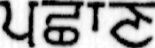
ਪਛਾਣ
